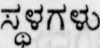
ಸ್ಥಳಗಳು
